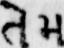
તેમ
